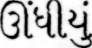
ઊંધીયું
